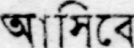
আসিবে
